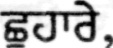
ਛੁਹਾਰੇ,
